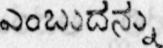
ಎಂಬುದನ್ನು
